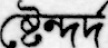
ষ্টেন্দর্দ
